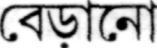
বেড়ানো
